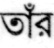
তাঁর
